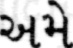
અમે
